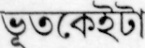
ভূতকেইটা
